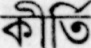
কীর্তি
